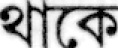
থাকে
